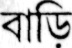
বাড়ি
